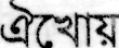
ঐখোয়
